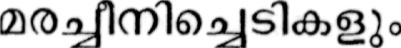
മരച്ചീനിച്ചെടികളും
